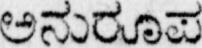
ಅನುರೂಪ
